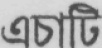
এচাটি
